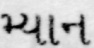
મ્યાન
